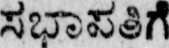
ಸಭಾಪತಿಗೆ
